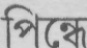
পিন্ধে
